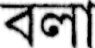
বলা
